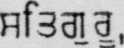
ਸਤਿਗੁਰੂ,
